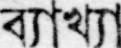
ব্যাখ্যা
